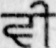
ਵੀ
